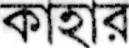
কাহার
